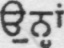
ਉਨ੍ਹਾਂ
